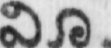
ಮೀ.
